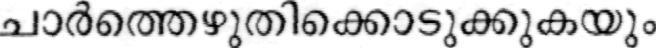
ചാര്‍ത്തെഴുതിക്കൊടുക്കുകയും
